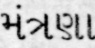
મંત્રણા
